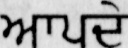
ਆਪਦੇ
